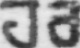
ਹਰ
